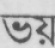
ভয়
